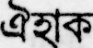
ঐহাক
